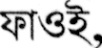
ফাওই,
